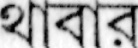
থাবার
